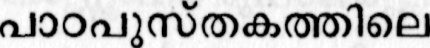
പാഠപുസ്തകത്തിലെ
